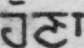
ਹੋਣਾ
